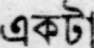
একটা
